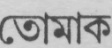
তোমাক
